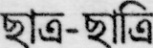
ছাত্র-ছাত্রি
